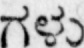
ಗಳು
